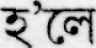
হ'লে
